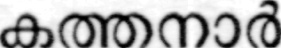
കത്തനാര്‍
